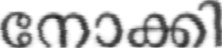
നോക്കി
